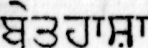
ਬੇਤਹਾਸ਼ਾ
